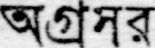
অগ্রসর
